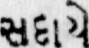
સદાયે
